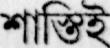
শাস্তিই
